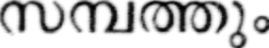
സമ്പത്തും
